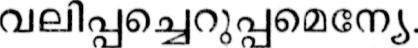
വലിപ്പച്ചെറുപ്പമെന്യേ.
